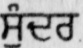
ਸੁੰਦਰ
